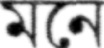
মনে
